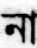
না
